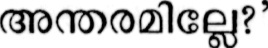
അന്തരമില്ലേ?'
